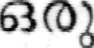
ഒരു
